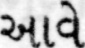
આવે
